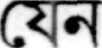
যেন
